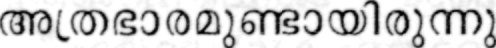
അത്രഭാരമുണ്ടായിരുന്നു
